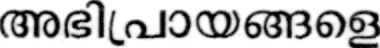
അഭിപ്രായങ്ങളെ
